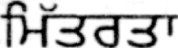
ਮਿੱਤਰਤਾ
